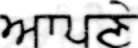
ਆਪਣੇ
